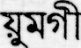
য়ুমগী
